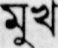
মুখ
